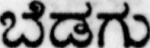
ಬೆಡಗು
